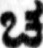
ಚ
